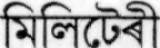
মিলিটেৰী
